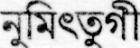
নুমিৎতুগী
